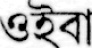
ওইবা
